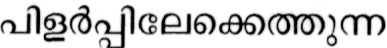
പിളര്‍പ്പിലേക്കെത്തുന്ന
